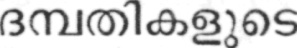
ദമ്പതികളുടെ
